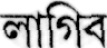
লাগিব
